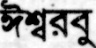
ঈশ্বরবু
